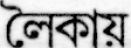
লৈকায়
